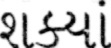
શક્યાં
